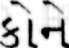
કોને
